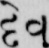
દેવ
